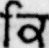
ਕਿ
